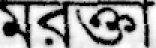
মরক্তা
